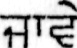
ਜਾਵੇ
